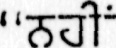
''ਨਹੀਂ
